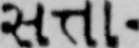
સત્તા-
